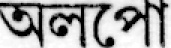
অলপো
